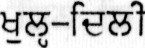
ਖੁਲ੍ਹ-ਦਿਲੀ
